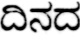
ದಿನದ
